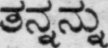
ತನ್ನನ್ನು
